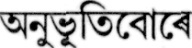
অনুভূতিবোৰে
